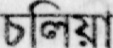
চলিয়া
